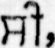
ਸੀ,
